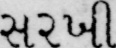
સરખી
